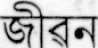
জীৱন
